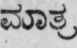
ಮಾತ್ರ
